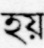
হয়
